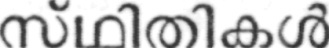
സ്ഥിതികള്‍
